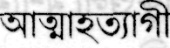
আত্মাহত্যাগী
